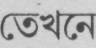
তেখনে
